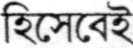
হিসেবেই
